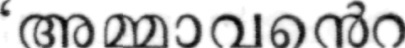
'അമ്മാവന്റെ
